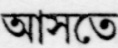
আসতে
